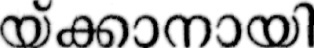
യ്ക്കാനായി
